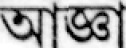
আজ্ঞা
